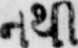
નથી
